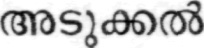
അടുക്കല്‍
